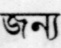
জন্য
